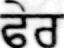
ਫੇਰ
